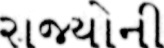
રાજ્યોની
